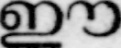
ഈ
